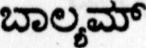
ಬಾಲ್ಯಮ್
